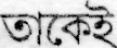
তাকেই
